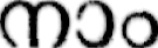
നാം
